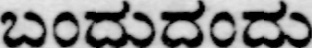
ಬಂದುದಂದು
